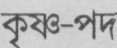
কৃষ্ণ-পদ
